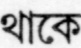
থাকে
